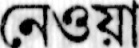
নেওয়া
